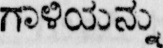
ಗಾಳಿಯನ್ನು
